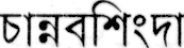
চান্নবশিংদা
